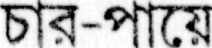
চার-পায়ে
